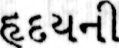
હ્રદયની
